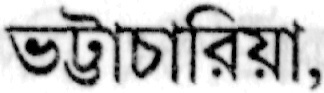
ভট্টাচারিয়া,
